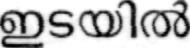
ഇടയില്‍
